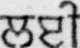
ਲਈ
